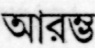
আরম্ভ
